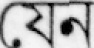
যেন
